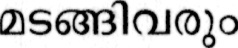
മടങ്ങിവരും
